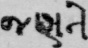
જણને
